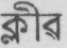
ক্লীৱ
